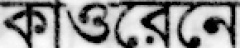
কাওরেনে
